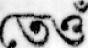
তেওঁ
